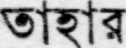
তাহার
